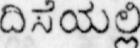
ದಿಸೆಯಲ್ಲಿ
